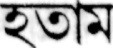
হতাম
